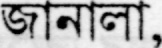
জানালা,
